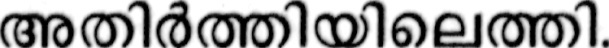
അതിര്‍ത്തിയിലെത്തി.
